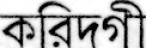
করিদগী
